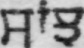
ਸਾਂਝ
